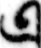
এ
